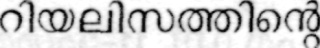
റിയലിസത്തിന്റെ
